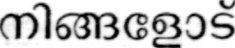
നിങ്ങളോട്
